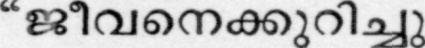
"ജീവനെക്കുറിച്ചു
